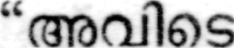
“അവിടെ
